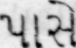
પાસે
